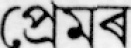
প্রেমৰ
